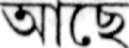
আছে
